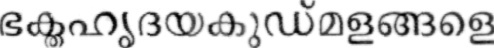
ഭക്തഹൃദയകുഡ്മളങ്ങളെ
